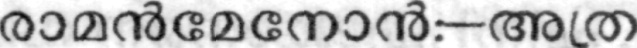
രാമന്‍മേനോന്‍:-അത്ര
